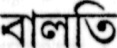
বালতি
